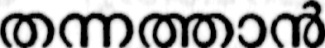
തന്നത്താന്‍
